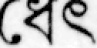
ধেৎ
